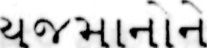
યજમાનોને
